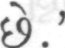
છે.'
